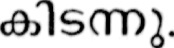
കിടന്നു.
